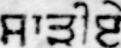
ਸਾੜੀਏ
